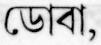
ডোবা,
